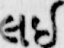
લઈ
